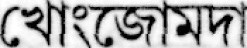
খোংজোমদা
